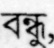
বন্ধু,
